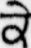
ਕੇ
